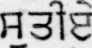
ਸੁਤੀਏ
